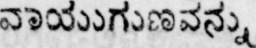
ವಾಯುಗುಣವನ್ನು
